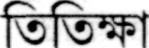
তিতিক্ষা
